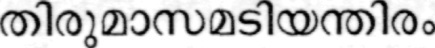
തിരുമാസമടിയന്തിരം
